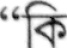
"কি
